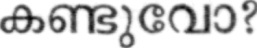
കണ്ടുവോ?
